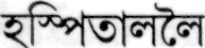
হস্পিতাললৈ
